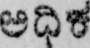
ಅಧಿಕ
